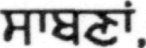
ਸਾਬਣਾਂ,
